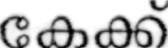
കേക്ക്
